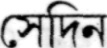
সেদিন
